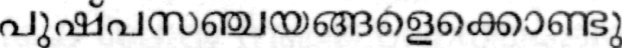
പുഷ്പസഞ്ചയങ്ങളെക്കൊണ്ടു
